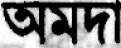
অমদা
